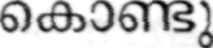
കൊണ്ടു
